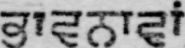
ਭਾਵਨਾਵਾਂ
